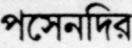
পসেনদির
